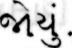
જોયું.
